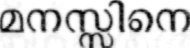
മനസ്സിനെ
